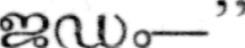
ജഡം-"
